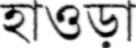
হাওড়া
